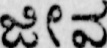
ಜೀವ
